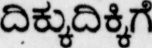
ದಿಕ್ಕುದಿಕ್ಕೆಗೆ
